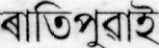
ৰাতিপুৱাই
